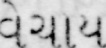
વેચાય
